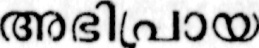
അഭിപ്രായ
